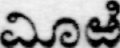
ಮೀಱೆ
